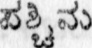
ಪಶ್ಚಿಮ
